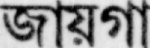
জায়গা
